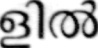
ളില്‍
